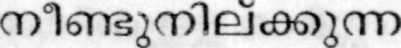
നീണ്ടുനില്ക്കുന്ന
